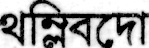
থম্লিবদো
